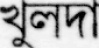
খুলদা
